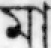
মা
